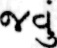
જવું
